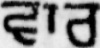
ਵਾਰ
